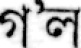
গ'ল
